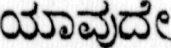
ಯಾವುದೇ
